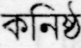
কনিষ্ঠ
